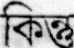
কিন্তু
